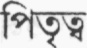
পিতৃত্ব
